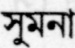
সুমনা
